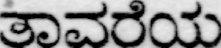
ತಾವರೆಯ
